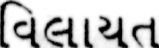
વિલાયત
